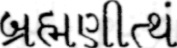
બ્રહ્મણીંત્થં
